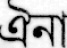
ঐনা
